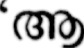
‘ആ
